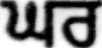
ਘਰ
